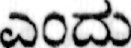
ಎಂದು
